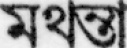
মথন্তা
